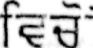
ਵਿਚੋਂ
